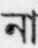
না
